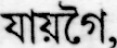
যায়গৈ,
